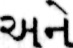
અને
